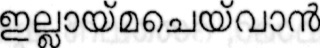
ഇല്ലായ്മചെയ്വാന്‍
